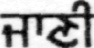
ਜਾਣੀ
